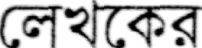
লেখকের
